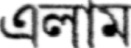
এলাম
